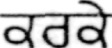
ਕਰਕੇ
